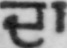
ਦਾ
